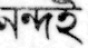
নন্দই
